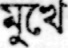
মুখে
